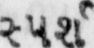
સ્પર્શ
